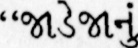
"જાડેજાનું
